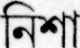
নিশা
